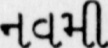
નવમી
